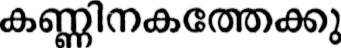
കണ്ണിനകത്തേക്കു
